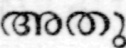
അതു
